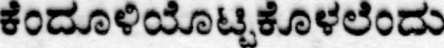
ಕೆಂದೂಳಿಯೊಟ್ಟಿಕೊಳಲೆಂದು
